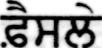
ਫ਼ੈਸਲੇ
